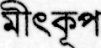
মীৎকূপ
